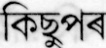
কিছুপৰ
